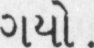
ગયો.
